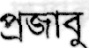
প্রজাবু
